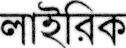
লাইরিক
